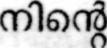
നിന്റെ
